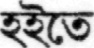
হইতে
